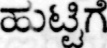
ಹುಟ್ಟಿಗೆ
